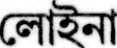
লোইনা
